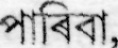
পাৰিবা,
